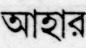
আহার
